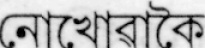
নোখোৱাকৈ
